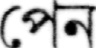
পেন
